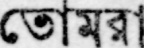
তোমরা
